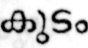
കുടം
